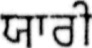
ਯਾਰੀ
